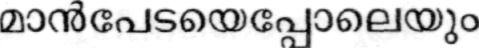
മാന്‍പേടയെപ്പോലെയും
